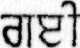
ਗਈ
